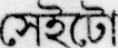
সেইটো
